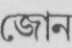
জোন
